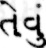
તેવું
